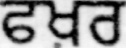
ਫਖ਼ਰ
